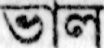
ভাল
